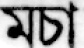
মচা
